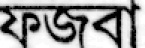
ফজবা
